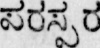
ಪರಸ್ಪರ
